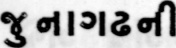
જુનાગઢની
